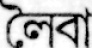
লৈবা
